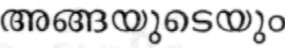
അങ്ങയുടെയും
